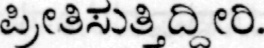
ಪ್ರೀತಿಸುತ್ತಿದ್ದೀರಿ.
